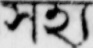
সহ্য
